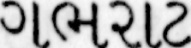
ગભરાટ
